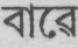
বাৱে
